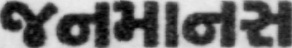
જનમાનસ
